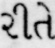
રીતે
